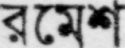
রমেশ
